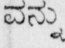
ವನ್ನು
